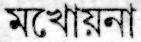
মখোয়না
